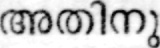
അതിനു
